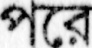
পরে
